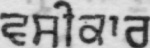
ਵਸੀਕਾਰ
